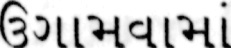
ઉગામવામાં
